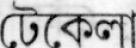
টেকেলা
